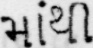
માંથી
